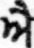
ਐ
